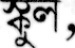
স্কুল,
